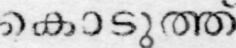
കൊടുത്ത്
